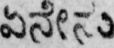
ಏನೇನು
